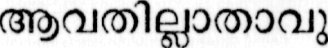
ആവതില്ലാതാവു
